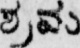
ಶ್ರಮ
